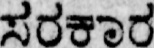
ಸರಕಾರ
